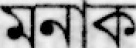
মনাক
